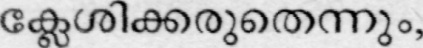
ക്ലേശിക്കരുതെന്നും,
